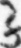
કે
